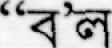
"ব'ল
